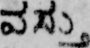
ವಸ್ತು
